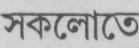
সকলোতে
